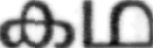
കഥ
